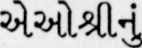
એઓશ્રીનું
